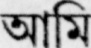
আমি
